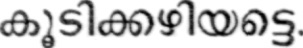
കൂടിക്കഴിയട്ടെ.
